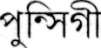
পুন্সিগী
